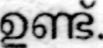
ഉണ്ട്.
